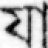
যা
